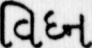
વિધ્ન
